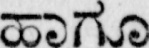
ಹಾಗೂ
